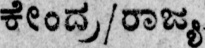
ಕೇಂದ್ರ/ರಾಜ್ಯ
